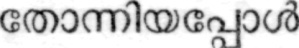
തോന്നിയപ്പോള്‍
